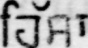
ਹਿੱਸਾ
